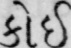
કોઈ
